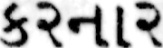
કરનાર
